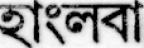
হাংলবা
